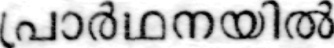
പ്രാര്‍ഥനയില്‍
